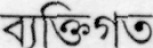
ব্যক্তিগত
